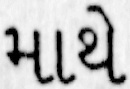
માથે
